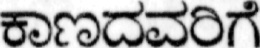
ಕಾಣದವರಿಗೆ
